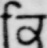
ਕਿ
